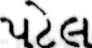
પટેલ
